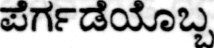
ಪೆರ್ಗಡೆಯೊಬ್ಬ
